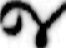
જ
